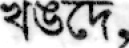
খঙদে,
